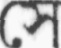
সে
